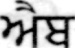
ਐਬ
